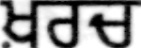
ਖ਼ਰਚ
